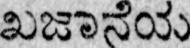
ಖಜಾನೆಯ
